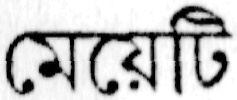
মেয়েটি
